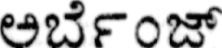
ಅರ್ಬೆಂಜ್
